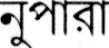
নুপারা
